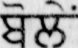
ਬੋਲੇਂ
